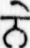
ਨੇ
